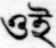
ওই
